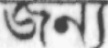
জন্য
